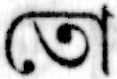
তো
